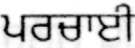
ਪਰਚਾਈ
